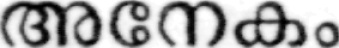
അനേകം
